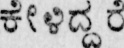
ಕೇಳಿದ್ದರೆ
